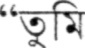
“তুমি
